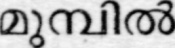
മുമ്പില്‍
